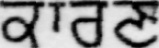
ਕਾਰਣ
